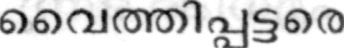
വൈത്തിപ്പട്ടരെ
